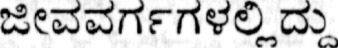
ಜೀವವರ್ಗಗಳಲ್ಲಿದ್ದು
